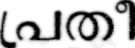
പ്രതീ
